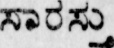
ಸಾರಸ್ತು
